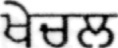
ਖੇਚਲ
